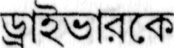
ড্রাইভারকে
